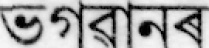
ভগৱানৰ
